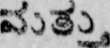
ಮತ್ತು
